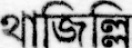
থাজিল্লি
